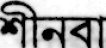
শীনবা
